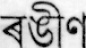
ৰঙীণ
